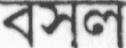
বসল
